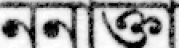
ননাক্তা
